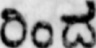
ರಿಂದ
